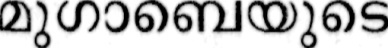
മുഗാബെയുടെ
